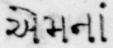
એમનાં
